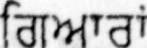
ਗਿਆਰਾਂ
